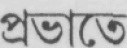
প্রভাতে
